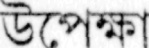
উপেক্ষা
